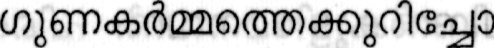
ഗുണകര്‍മ്മത്തെക്കുറിച്ചോ
